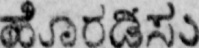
ಹೊರಡಿಸು
